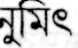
নুমিৎ
